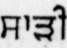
ਸਾੜੀ
